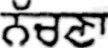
ਨੱਚਣਾ
